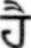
ਹੈ
